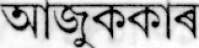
আজুককাৰ
